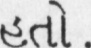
હતો.
